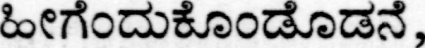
ಹೀಗೆಂದುಕೊಂಡೊಡನೆ,
